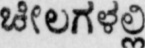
ಚೀಲಗಳಲ್ಲಿ
